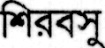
শিরবসু
